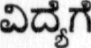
ವಿದ್ಯೆಗೆ
